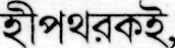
হীপথরকই,
